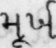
મૂર્ખ
